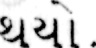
થયો.
